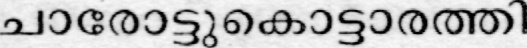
ചാരോട്ടുകൊട്ടാരത്തി
